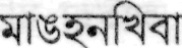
মাঙহনখিবা
